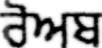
ਰੋਅਬ
